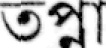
তপ্না
